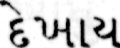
દેખાય
